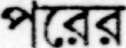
পরের
